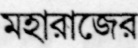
মহারাজের
